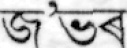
জ'ভৰ
